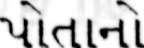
પોતાનો
